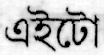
এইটো
